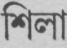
শিলা
